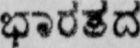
ಭಾರತದ
